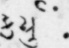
કર્યું.
